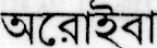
অরোইবা
